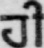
ਹੀ
